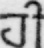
ਹੀ
